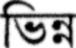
ভিন্ন
